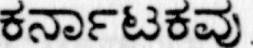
ಕರ್ನಾಟಕವು
